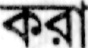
করা
